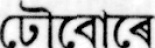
ঢৌবোৰে
